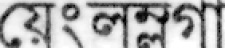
য়েংলম্লগা
